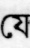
যে
